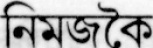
নিমজকৈ
